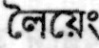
লৈয়েং
